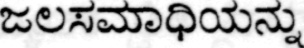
ಜಲಸಮಾಧಿಯನ್ನು
